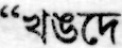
“খঙদে
